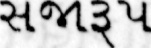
સજારૂપ
